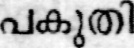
പകുതി
